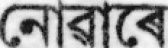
নোৱাৰে
